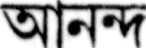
আনন্দ
